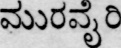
ಮುರವೈರಿ
